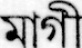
মাগী
